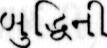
બુદ્ધિની
